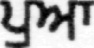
ਪੁਆ
